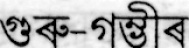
গুৰু-গম্ভীৰ
